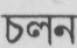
চলন
